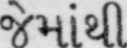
જેમાંથી
